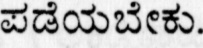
ಪಡೆಯಬೇಕು.
